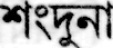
শংদুনা
